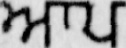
ਆਪ
